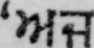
'ਅਜ
